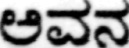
ಅವನ
